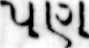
પણ
